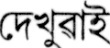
দেখুৱাই
